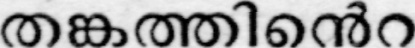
തങ്കത്തിന്റെ
